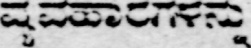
ವ್ಯವಹಾರಗಳನ್ನು
